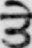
ਤੇ
